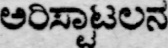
ಅರಿಸ್ಟಾಟಲನ
